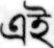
এই
